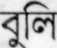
বুলি
